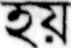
হয়
